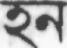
হন
